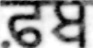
ਫ਼ਬ
